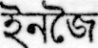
ইনজৈ
